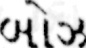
બોઝ
